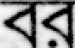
বর
